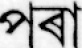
পৰা
